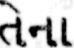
તેના
